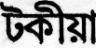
টকীয়া
